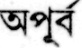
অপূর্ব
